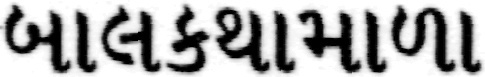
બાલકથામાળા
